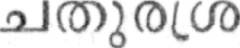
ചതുരശ്ര
